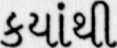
કયાંથી
